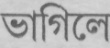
ভাগিলে
